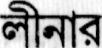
লীনার
